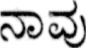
ನಾವು
